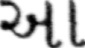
આ
